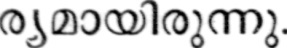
ര്യമായിരുന്നു.
